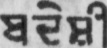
ਬਦੇਸ਼ੀ
